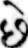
છે
